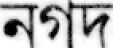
নগদ
